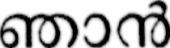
ഞാന്‍
